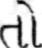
તો
